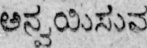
ಅನ್ವಯಿಸುವ
